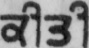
ਕੀਤੀ
